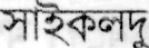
সাইকলদু
